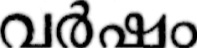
വര്‍ഷം
